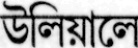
উলিয়ালে
